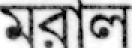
মরাল
